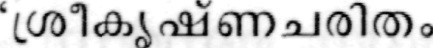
'ശ്രീകൃഷ്ണചരിതം
